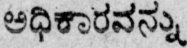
ಅಧಿಕಾರವನ್ನು
